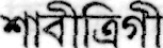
শাবীত্রিগী
